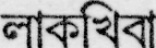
লাকখিবা
